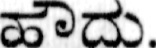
ಹೌದು.
